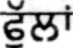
ਫੁੱਲਾਂ
